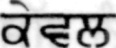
ਕੇਵਲ
